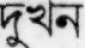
দুখন
